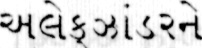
અલેક્ઝાંડરને
